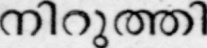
നിറുത്തി
